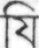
যি
